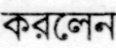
করলেন
